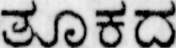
ತೂಕದ
